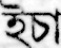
ইচা
